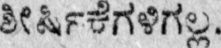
ಶೀರ್ಷಿಕೆಗಳಿಗಲ್ಲ.
